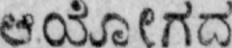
ಆಯೋಗದ
